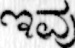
ಇವು
